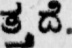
ತ್ತದೆ.
